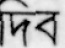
দিব
